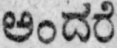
ಅಂದರೆ
